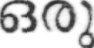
ഒരു
